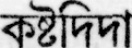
কষ্টদিদা
